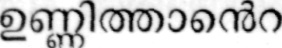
ഉണ്ണിത്താന്റെ
